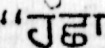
''ਹੱਛਾ
